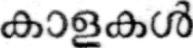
കാളകള്‍
